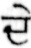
ਦੇ
